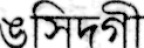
ঙসিদগী
